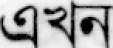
এখন
